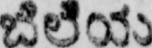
ಬೆಲೆಯ
